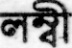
লম্বী
